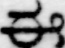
ಈ
